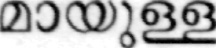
മായുള്ള
